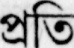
প্রতি
